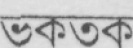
ভকতক
